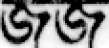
জজ
